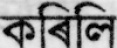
কৰিলি
